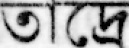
তাদ্রে
